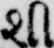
શી
